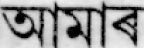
আমাৰ
